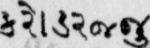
કરોડરજ્જુ
